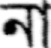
না
